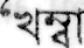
‘খম্বা
